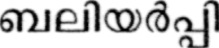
ബലിയര്‍പ്പി
